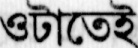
ওটাতেই
